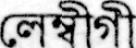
লেম্বীগী
